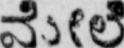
ಮೇಲೆ
